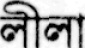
লীলা
